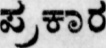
ಪ್ರಕಾರ
